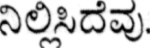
ನಿಲ್ಲಿಸಿದೆವು.
